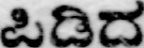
ಪಿಡಿದ
